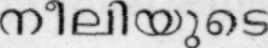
നീലിയുടെ
